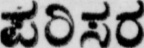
ಪರಿಸರ
